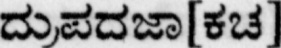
ದ್ರುಪದಜಾ[ಕಚ]
